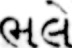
ભલે
